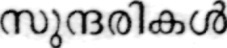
സുന്ദരികള്‍
